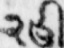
રહી
